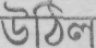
উঠিল
